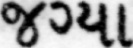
જગ્યા
